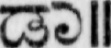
ಡಾ||
